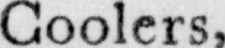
Coolers,
